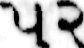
પર
